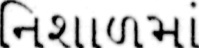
નિશાળમાં
